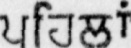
ਪਹਿਲਾਂ
